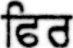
ਫਿਰ
